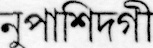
নুপাশিদগী
